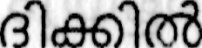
ദിക്കില്‍
